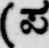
(ಪ
